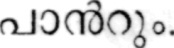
പാന്റും.
